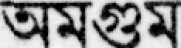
অমগুম
